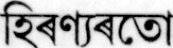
হিৰণ্যৰতো
